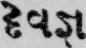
દેવજ્ઞ
